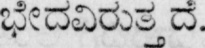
ಭೇದವಿರುತ್ತದೆ.
